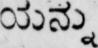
ಯನ್ನು
